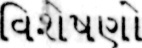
વિશેષણો
